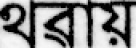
থৱায়
